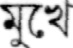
মুখে
